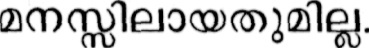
മനസ്സിലായതുമില്ല.
